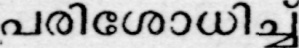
പരിശോധിച്ച്
